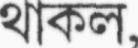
থাকল,
